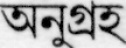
অনুগ্রহ
